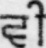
ਵੀ
